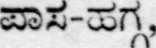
ಪಾಸ-ಹಗ್ಗ,
